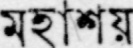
মহাশয়
